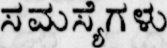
ಸಮಸ್ಯೆಗಳು
